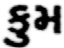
કુમ
